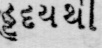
હ્રદયથી
